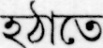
হঠাতে
